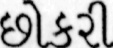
છોકરી
